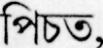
পিচত,
